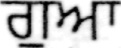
ਗੁਆ
